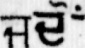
ਜਦੋਂ
